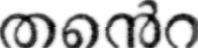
തന്റെ
